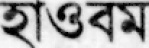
হাওবম
